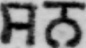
ਸਨ
